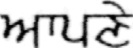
ਆਪਣੇ
